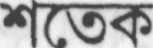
শতেক
